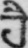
ਹੈ
